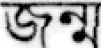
জন্ম
